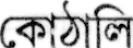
কোঠালি
